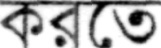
করতে
